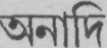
অনাদি
